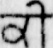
ਕੀ
